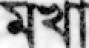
মখা
